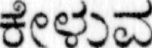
ಕೇಳುವ
